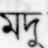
মদু
